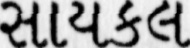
સાયકલ
